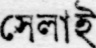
সেলাই
